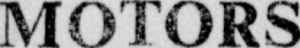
MOTORS
